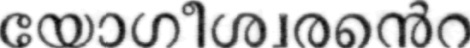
യോഗീശ്വരന്റെ
